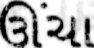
ઊંચા
